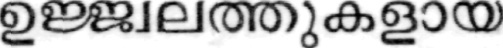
ഉജ്ജ്വലത്തുകളായ
